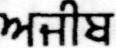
ਅਜੀਬ
